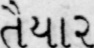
તૈયાર
